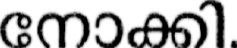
നോക്കി.
